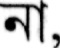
না,
